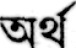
অর্থ
